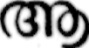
ആ
